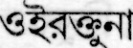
ওইরক্তুনা
